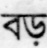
বড়
